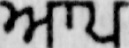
ਆਪ
